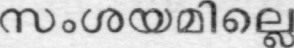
സംശയമില്ലെ
